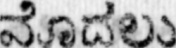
ಮೊದಲು
